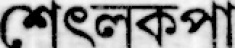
শেৎলকপা
